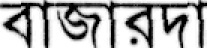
বাজারদা
